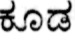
ಕೂಡ
